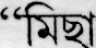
"মিছা
